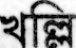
খল্লি
